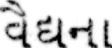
વૈધના
